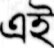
এই
